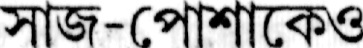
সাজ-পোশাকেও
